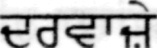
ਦਰਵਾਜ਼ੇ
